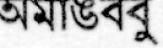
অমাঙববু
